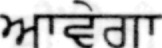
ਆਵੇਗਾ
